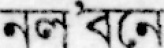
নল'বনে
